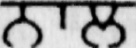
ਨਾਲ
